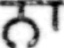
ਨਾ
